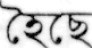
হৈছে
